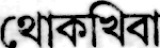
থোকখিবা
